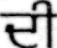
ਦੀ
